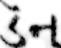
ડૅન
